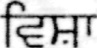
ਵਿਸ਼ਾ
